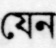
যেন
